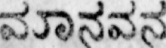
ಮಾನವನ
